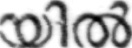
യില്‍
